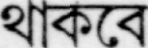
থাকবে
